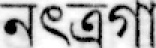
নৎত্রগা
